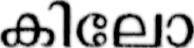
കിലോ
